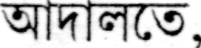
আদালতে,
